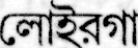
লোইরগা
